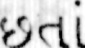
છતાં
